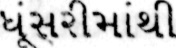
ધૂંસરીમાંથી
